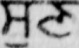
ਸੁਣ
